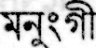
মনুংগী
